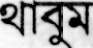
থাবুম
